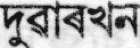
দুৱাৰখন
